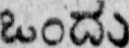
ಒಂದು
